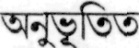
অনুভূতিত
